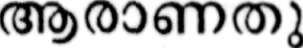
ആരാണതു
